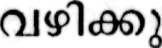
വഴിക്കു
